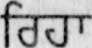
ਰਿਹਾ
